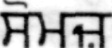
ਸੋਮਜ਼
